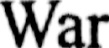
War
